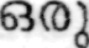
ഒരു
